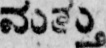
ಮತ್ತು
